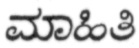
ಮಾಹಿತಿ
